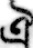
ঐ
